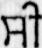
ਸੀ
